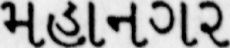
મહાનગર
